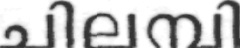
ചിലമ്പി
